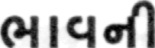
ભાવની
